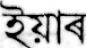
ইয়াৰ
